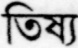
তিষ্য
